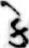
કે
